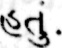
હતું.
